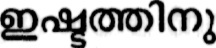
ഇഷ്ടത്തിനു
